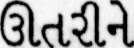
ઊતરીને
